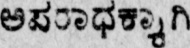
ಅಪರಾಧಕ್ಕಾಗಿ
